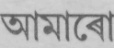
আমাৰো
